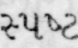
સ્પષ્ટ
